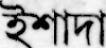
ইশাদা
